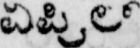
ಏಪ್ರಿಲ್
